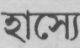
হাস্যে
